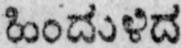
ಹಿಂದುಳಿದ
